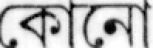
কোনো
